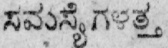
ಸಮಸ್ಯೆಗಳತ್ತ
